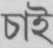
চাই
